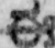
ಈ
